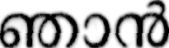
ഞാന്‍
